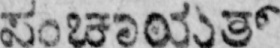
ಪಂಚಾಯತ್
